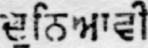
ਦੁਨਿਆਵੀ
